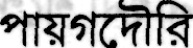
পায়গদৌরি
